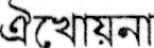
ঐখোয়না
